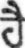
ਹੈ
